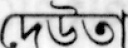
দেউতা
